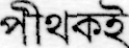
পীথকই
